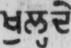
ਖੁਲ੍ਹਦੇ
